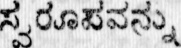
ಸ್ವರೂಪವನ್ನು
